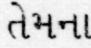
તેમના
